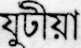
যুটীয়া
